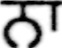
ਨਾ
